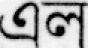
এল
